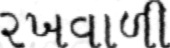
રખવાળી
